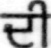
ਦੀ
